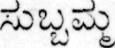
ಸುಬ್ಬಮ್ಮ
